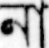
না
